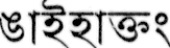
ঙাইহাক্তং
